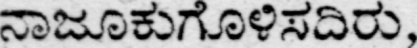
ನಾಜೂಕುಗೊಳಿಸದಿರು,
